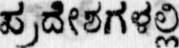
ಪ್ರದೇಶಗಳಲ್ಲಿ
